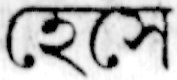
হেসে
